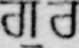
ਗੁਰ
